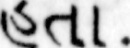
હતા.
